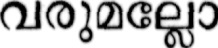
വരുമല്ലോ
